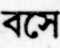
বসে
